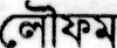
লৌফম
